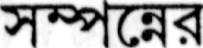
সম্পন্নের
